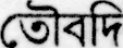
তৌবদি
